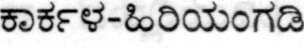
ಕಾರ್ಕಳ-ಹಿರಿಯಂಗಡಿ
